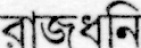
রাজধনি
